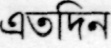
এতদিন
